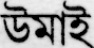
উমাই
